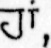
ਹਾਂ,
